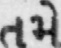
તમે
